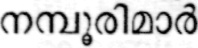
നമ്പൂരിമാര്‍
